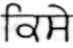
ਕਿਸੇ
